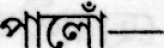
পালোঁ-
